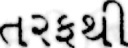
તરફથી
